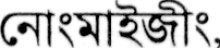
নোংমাইজীং,
